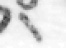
চং
